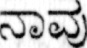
ನಾವು
